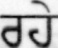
ਰਹੇ
